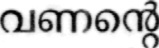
വണന്റെ
